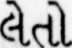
લેતો
